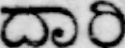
ದಾರಿ
